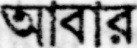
আবার
